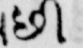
પછી
